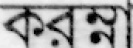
করম্না
